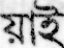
য়াই
